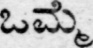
ಒಮ್ಮೆ
